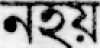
নহয়
